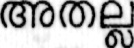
അതല്ല
